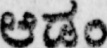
ಆಡಂ
